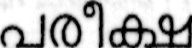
പരീക്ഷ
